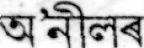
অ'নীলৰ
